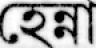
হেন্না
